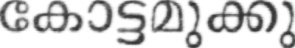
കോട്ടമുക്കു
